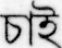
চাই
